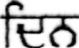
ਦਿਨ
